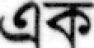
এক
